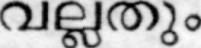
വല്ലതും
